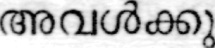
അവള്‍ക്കു
